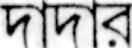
দাদার
